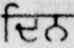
ਦਿਨ
